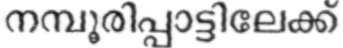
നമ്പൂരിപ്പാട്ടിലേക്ക്
